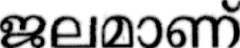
ജലമാണ്
